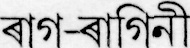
ৰাগ-ৰাগিনী
